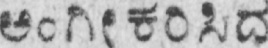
ಅಂಗೀಕರಿಸಿದ
